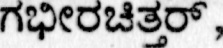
ಗಭೀರಚಿತ್ತರ್,
